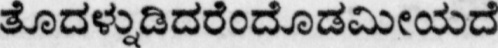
ತೊದಳ್ನುಡಿದರೆಂದೊಡಮೀಯದೆ
